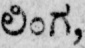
ಲಿಂಗ,
